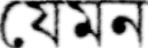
যেমন
